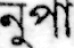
নুপা
